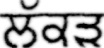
ਲੱਕੜ
